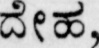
ದೇಹ,
